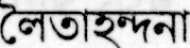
লৈতাহন্দনা
